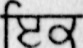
ਇਕ
